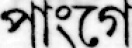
পাংগে
